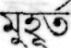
মুহূর্ত
